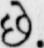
છે.
